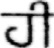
ਹੀ
